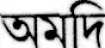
অমদি
